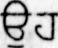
ਉਹ
